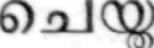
ചെയ്ത
